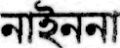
নাইননা
